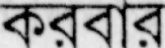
করবার
